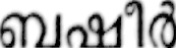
ബഷീര്‍
